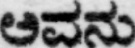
ಅವನು
